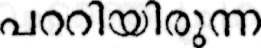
പററിയിരുന്ന
